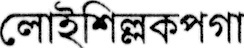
লোইশিল্লকপগা
